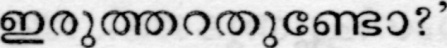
ഇരുത്തറതുണ്ടോ?’
